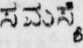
ಸಮಸ್ಯೆ
